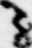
કે
